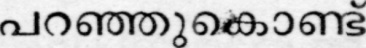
പറഞ്ഞുകൊണ്ട്
